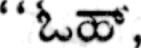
"ಓಹ್,
